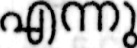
എന്നു
